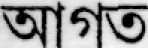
আগত
